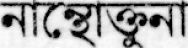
নান্থোক্তুনা
